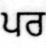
ਪਰ
